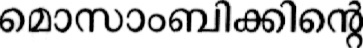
മൊസാംബിക്കിന്റെ
